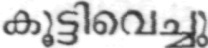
കൂട്ടിവെച്ചു
